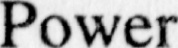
Power
